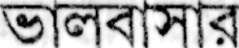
ভালবাসার
